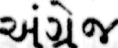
અંગ્રેજ
